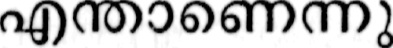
എന്താണെന്നു
